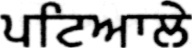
ਪਟਿਆਲੇ
